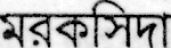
মরকসিদা
